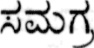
ಸಮಗ್ರ
